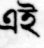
এই
